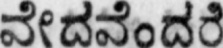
ವೇದವೆಂದರೆ
